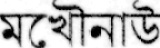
মখৌনাউ
